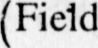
(Field
